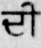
ਦੀ
